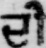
ਦੀ
